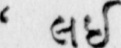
'લઈ
